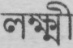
লক্ষ্মী
